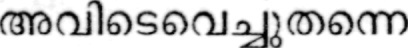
അവിടെവെച്ചുതന്നെ
